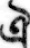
ঐ
